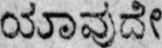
ಯಾವುದೇ
